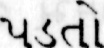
પડતો
